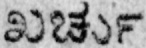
ಖರ್ಚು
